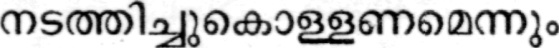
നടത്തിച്ചുകൊള്ളണമെന്നും
